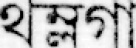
থম্লগা
